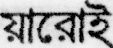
য়ারোই
